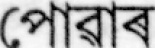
পোৱাৰ
